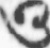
ও
